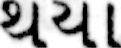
થયા
